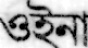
ওইনা
